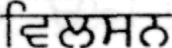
ਵਿਲਸਨ
